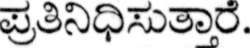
ಪ್ರತಿನಿಧಿಸುತ್ತಾರೆ.
